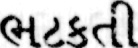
ભટકતી
